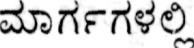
ಮಾರ್ಗಗಳಲ್ಲಿ
